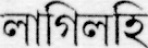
লাগিলহি
